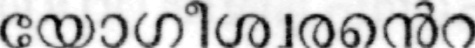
യോഗീശ്വരന്റെ
